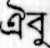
ঐবু
